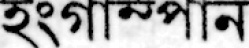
হংগাম্পান
